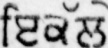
ਇਕੱਲੇ
